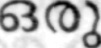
ഒരു
